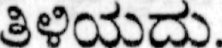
ತಿಳಿಯದು.
